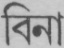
বিনা
